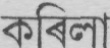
কৰিলা
